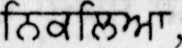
ਨਿਕਲਿਆ,
